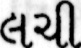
લચી
